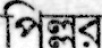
পিল্লর
